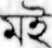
মই
